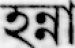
হন্না
